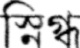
স্নিগ্ধ
